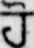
ਹੋ
